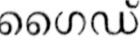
ഗൈഡ്
